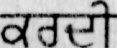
ਕਰਦੀ
